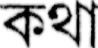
কথা
